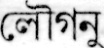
লৌগনু
